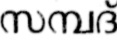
സമ്പദ്
